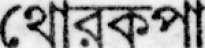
থোরকপা
